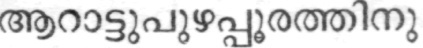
ആറാട്ടുപുഴപ്പൂരത്തിനു
